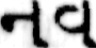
નવ
